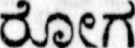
ರೋಗ
